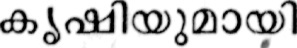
കൃഷിയുമായി
